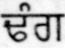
ਢੰਗ
